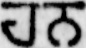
ਹਨ
